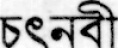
চৎনবী
